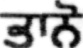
ਭਾਨੋ
